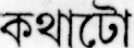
কথাটো
